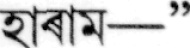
হাৰাম-"
